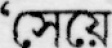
'সেয়ে
